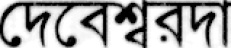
দেবেশ্বরদা
